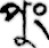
পুং
